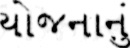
યોજનાનું
